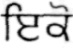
ਇਕੋ
